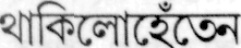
থাকিলোহেঁতেন
